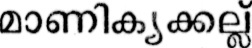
മാണിക്യക്കല്ല്
